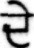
ਦੇ
